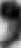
વધૂ'
